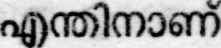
എന്തിനാണ്
